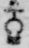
ਨੂੰ
